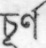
চূর্ণ
